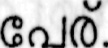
പേര്.
